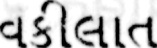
વકીલાત
